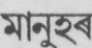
মানুহৰ
